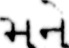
મને
